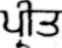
ਪ੍ਰੀਤ
